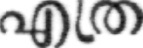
എത്ര
